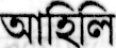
আহিলি
